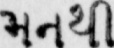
મનથી
